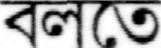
বলতে
